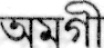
অমগী
